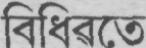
বিধিৱতে
